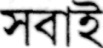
সবাই
